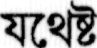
যথেষ্ট
